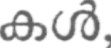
കള്‍,
